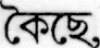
কৈছে,
